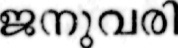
ജനുവരി
